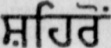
ਸ਼ਹਿਰੋਂ
